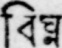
বিঘ্ন
